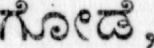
ಗೋಡೆ,
